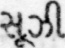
સૂઝી
